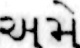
અમે
